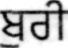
ਬੁਰੀ
